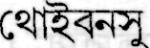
থোইবনসু
